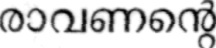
രാവണന്റെ
